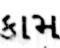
કામ
